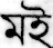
মই
